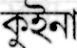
কুইনা
